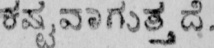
ಕಷ್ಟವಾಗುತ್ತದೆ.
